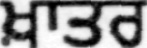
ਖ਼ਾਤਰ
